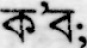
ক'ব;
